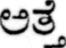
ಅತ್ತೆ
